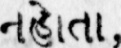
નહોતા,
